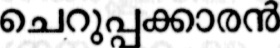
ചെറുപ്പക്കാരന്‍
